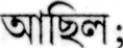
আছিল;
